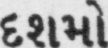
દશમો
